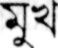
মুখ
